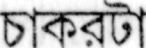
চাকরটা
